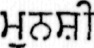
ਮੁਨਸ਼ੀ
